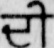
ਦੀ
